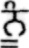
ਨੂੰ
